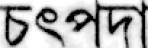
চৎপদা
